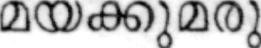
മയക്കുമരു
